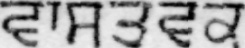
ਵਾਸਤਵਕ
